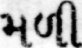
મળી
